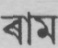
ৰাম
